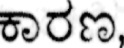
ಕಾರಣ,
